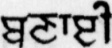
ਬਣਾਈ
